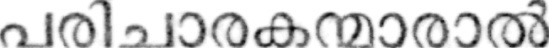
പരിചാരകന്മാരാല്‍
